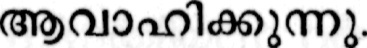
ആവാഹിക്കുന്നു.
